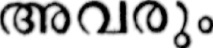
അവരും
